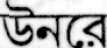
উনরে
